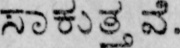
ಸಾಕುತ್ತವೆ.
